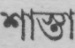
শাস্তা
